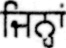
ਜਿਨ੍ਹਾਂ
